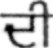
ਦੀ
